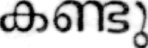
കണ്ടു
